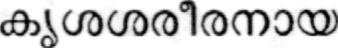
കൃശശരീരനായ
